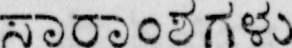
ಸಾರಾಂಶಗಳು
